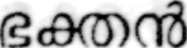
ഭക്തന്‍
